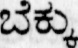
ಬೆಕ್ಕು
